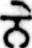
ਨੇ
